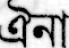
ঐনা
